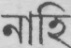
নাহি
